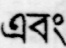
এবং
